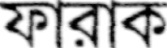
ফারাক
